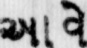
આવે
